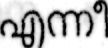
എന്നീ
